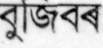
বুজিবৰ
